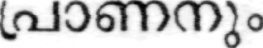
പ്രാണനും
